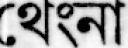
থেংনা
